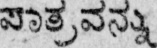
ಪಾತ್ರವನ್ನು
